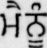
ਮੈਨੂੰ
